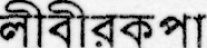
লীবীরকপা
